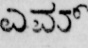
ಎಮ್
